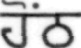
ਹੋਂਠ
